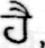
ਹੈ,
